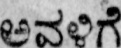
ಅವಳಿಗೆ
